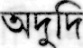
অদুদি
